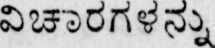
ವಿಚಾರಗಳನ್ನು
